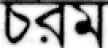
চরম
